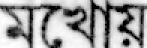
মখোয়
